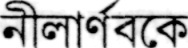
নীলার্ণবকে
